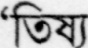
‘তিষ্য
